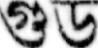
গুড
